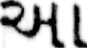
આ
